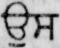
ਉਸ
